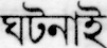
ঘটনাই
